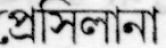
প্রেসিলানা
